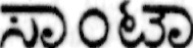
ಸಾಂಟಾ
